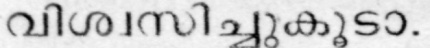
വിശ്വസിച്ചുകൂടാ.
